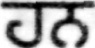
ਹਨ
